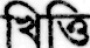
খিত্তি
